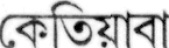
কেতিয়াবা
